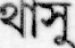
থাসু
